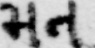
મન
